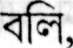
বলি,
